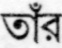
তাঁর
